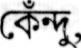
কেঁন্দু,
